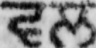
ਵਲ
